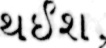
થઈશ,
